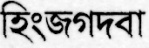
হিংজগদবা
